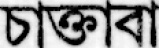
চাক্তাবা
